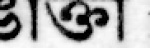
ঙাক্তা
